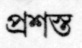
প্রশস্ত
